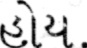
હોય.
